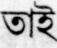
তাই
